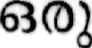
ഒരു
